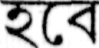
হবে
